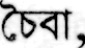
চৈবা,
